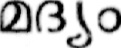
മദ്യം
